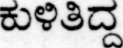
ಕುಳಿತಿದ್ದ
